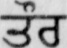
ਤੌਰ
